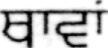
ਥਾਵਾਂ
